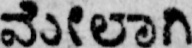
ಮೇಲಾಗಿ
